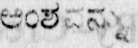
ಅಂಶವನ್ನು
